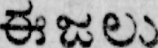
ಈಜಲು
